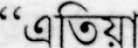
"এতিয়া
